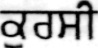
ਕੁਰਸੀ
